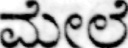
ಮೇಲೆ
